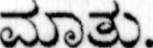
ಮಾತು.
